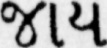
જાય
